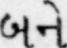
બને
